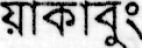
য়াকাবুং
